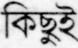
কিছুই
